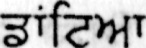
ਡਾਂਟਿਆ
